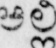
ಅಲ್ಲಿ
